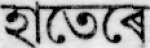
হাতেৰে
